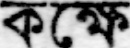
কক্ষে
